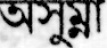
অসুম্না
